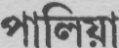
পালিয়া
